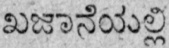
ಖಜಾನೆಯಲ್ಲಿ
